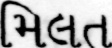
મિલત
